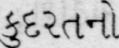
કુદરતનો
